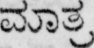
ಮಾತ್ರ
